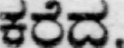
ಕರೆದ.
